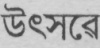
উৎসৱে
